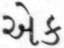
એક
